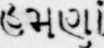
હમણાં
